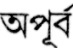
অপূর্ব
